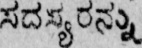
ಸದಸ್ಯರನ್ನು
